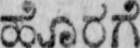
ಹೊರಗೆ
